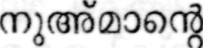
നുഅ്മാൻ്റെ
